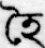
হৈ
